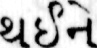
થઈને
